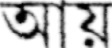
আয়
